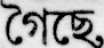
গৈছে,
